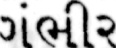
ગંભીર
